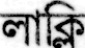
লাক্লি
